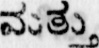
ಮತ್ತು
